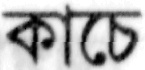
কাচে
